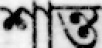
শান্ত
